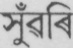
সুঁৱৰি
